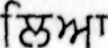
ਲਿਆ
